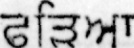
ਫੜਿਆ
